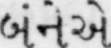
બંનેએ
